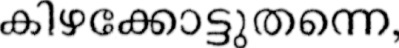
കിഴക്കോട്ടുതന്നെ,
